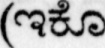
(ಇಕೊ
